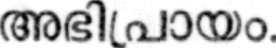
അഭിപ്രായം.
